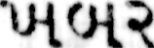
ખબર
